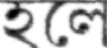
হলে
